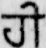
ਹੀ
